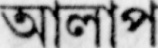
আলাপ
